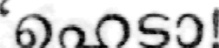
'ഹെടാ!
